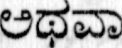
ಅಥವಾ
